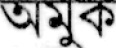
অমুক
